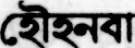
হৌহনবা
